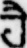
ਹੈ
